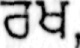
ਰਖ,
